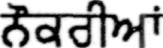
ਨੌਕਰੀਆਂ
